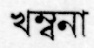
খম্বনা
